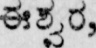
ಈಶ್ವರ,
